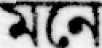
মনে
